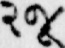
રજૂ
